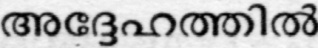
അദ്ദേഹത്തില്‍
